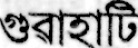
গুৱাহাটি
